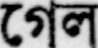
গেল
